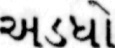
અડધો
